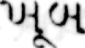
ખૂબ
